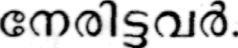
നേരിട്ടവര്‍.
